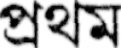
প্রথম
